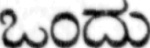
ಒಂದು
